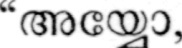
“അയ്യോ,
